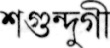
শগুন্দুগী
